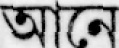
আনে
